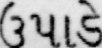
ઉપાડે
